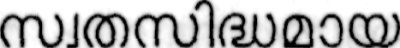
സ്വതസിദ്ധമായ
